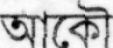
আকৌ
